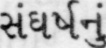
સંઘર્ષનું
